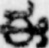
ಈ
